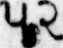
પર
